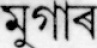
মুগাৰ
